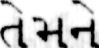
તેમને
